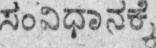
ಸಂವಿಧಾನಕ್ಕೆ
